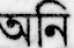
অনি
